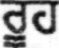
ਰੂਹ
